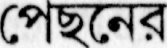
পেছনের
